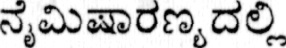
ನೈಮಿಷಾರಣ್ಯದಲ್ಲಿ
